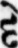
દે
